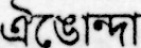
ঐঙোন্দা
